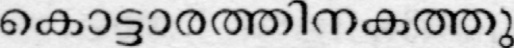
കൊട്ടാരത്തിനകത്തു
